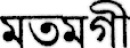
মতমগী
